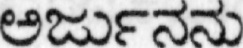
ಅರ್ಜುನನು
